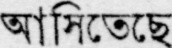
আসিতেছে
